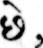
છે,
